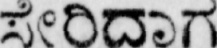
ಸೇರಿದಾಗ
